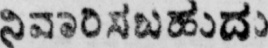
ನಿವಾರಿಸಬಹುದು
